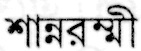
শান্নরম্মী
